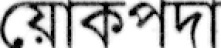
য়োকপদা
